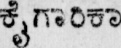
ಕೈಗಾರಿಕಾ
